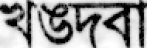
খঙদবা
